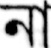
না
